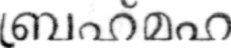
ബ്രഹ്മഹ
